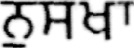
ਨੁਸਖਾ
